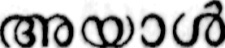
അയാള്‍
